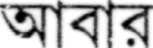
আবার
